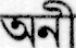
অনী
